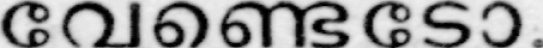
വേണ്ടെടോ.
